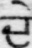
ਦੇ
